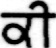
ਕੀ
